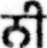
ਨੀ
